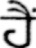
ਹੈਂ
